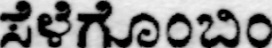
ಸೆಳೆಗೊಂಬಿಂ
